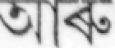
আৰু
